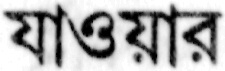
যাওয়ার
